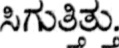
ಸಿಗುತ್ತಿತ್ತು.
